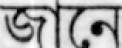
জানে
